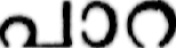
പാറ
